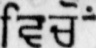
ਵਿਚੋਂ
